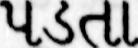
પડતા
